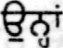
ਉਨ੍ਹਾਂ
